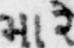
મારે
